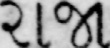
રાજા
